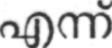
എന്ന്
